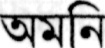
অমনি
